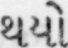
થયો
